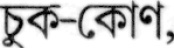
চুক-কোণ,
